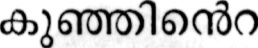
കുഞ്ഞിന്റെ
